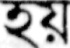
হয়
